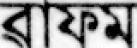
ৱাফম
